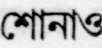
শোনাও
